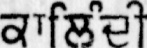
ਕਾਲਿੰਦੀ
